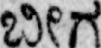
ಬೀಗ
